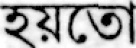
হয়তো
